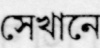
সেখানে
